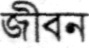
জীবন
